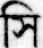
সি
